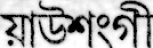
য়াউশংগী
